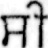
ਸੀ
